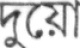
দুয়ো
